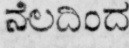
ನೆಲದಿಂದ
